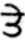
ਤੇ
